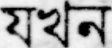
যখন
